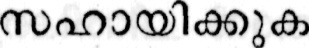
സഹായിക്കുക
